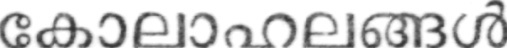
കോലാഹലങ്ങള്‍
